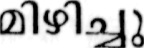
മിഴിച്ചു
